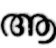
ആ
